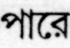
পারে
